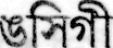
ঙসিগী
